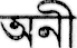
অনী
